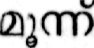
മൂന്ന്
